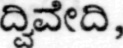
ದ್ವಿವೇದಿ,
